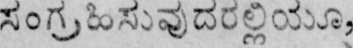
ಸಂಗ್ರಹಿಸುವುದರಲ್ಲಿಯೂ,
